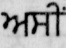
ਅਸੀਂ
